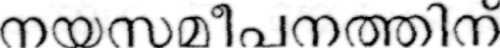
നയസമീപനത്തിന്
